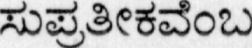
ಸುಪ್ರತೀಕವೆಂಬ
